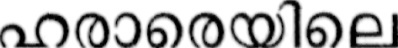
ഹരാരെയിലെ
